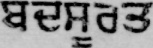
ਬਦਸੂਰਤ
